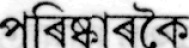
পৰিষ্কাৰকৈ
